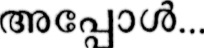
അപ്പോള്‍...
